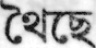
থৈছে
